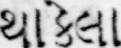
થાકેલા
